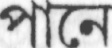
পানে
